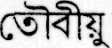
তৌবীয়ু
